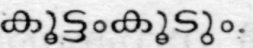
കൂട്ടംകൂടും
